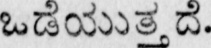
ಒಡೆಯುತ್ತದೆ.
